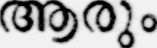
ആരും
